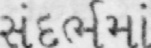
સંદર્ભમાં
